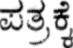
ಪತ್ರಕ್ಕೆ
